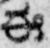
ಈ
